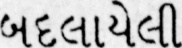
બદલાયેલી
